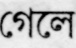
গেলে
